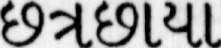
છત્રછાયા
